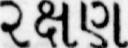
રક્ષણ
